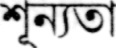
শূন্যতা
